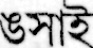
ঙসাই
